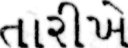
તારીખે
